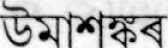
উমাশঙ্কৰ
